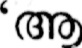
'ആ
